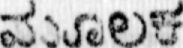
ಮೂಲಕ
